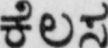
ಕೆಲಸ
